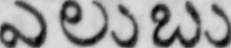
ಎಲುಬು
